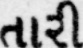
તારી
